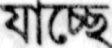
যাচ্ছে
